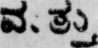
ಮತ್ತು
